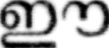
ഈ
